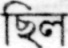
ছিল
